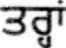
ਤਰ੍ਹਾਂ
